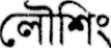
লৌশিং
